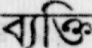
ব্যক্তি
